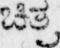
ಚಿತ್ರ
